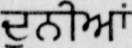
ਦੁਨੀਆਂ
